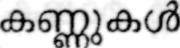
കണ്ണുകള്‍
